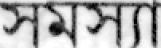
সমাস্যা
